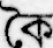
কৈ
